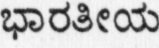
ಭಾರತೀಯ
